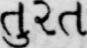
તુરત
